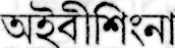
অইবীশিংনা
